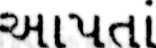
આપતાં
